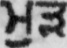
ਮੁੜ
